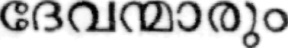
ദേവന്മാരും
